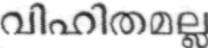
വിഹിതമല്ല.
